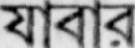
যাবার
